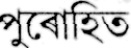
পুৰোহিত
